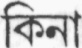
কিনা
